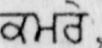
ਕਮਰੇ,
